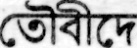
তৌবীদে
